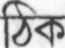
ঠিক
